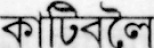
কাটিবলৈ
